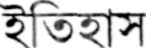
ইতিহাস
